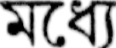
মধ্যে
